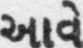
આવે
